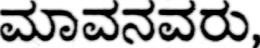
ಮಾವನವರು,
